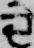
ਦੇ
